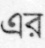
এর
